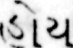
હોય
